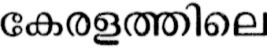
കേരളത്തിലെ
